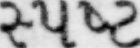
સ્પષ્ટ
